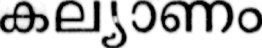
കല്യാണം
